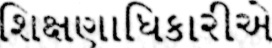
શિક્ષણાધિકારીએ
